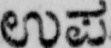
ಉಪ
